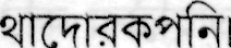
থাদোরকপনি।
